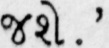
જશે.'
